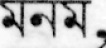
মনম,
